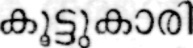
കൂട്ടുകാരി
